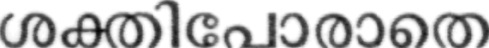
ശക്തിപോരാതെ
